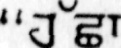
''ਹੱਛਾ
